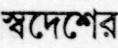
স্বদেশের
